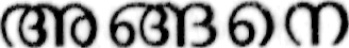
അങ്ങനെ
